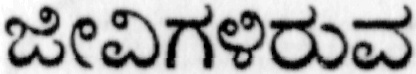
ಜೀವಿಗಳಿರುವ
